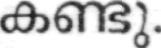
കണ്ടു.
